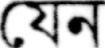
যেন
